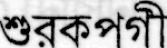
শুরকপগী
